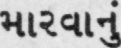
મારવાનું
